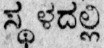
ಸ್ಥಳದಲ್ಲಿ
